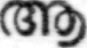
ആ
